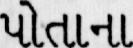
પોતાના
